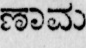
ಣಾಮ
